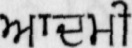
ਆਦਮੀ
